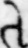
તે
